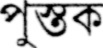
পুস্তক
